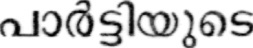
പാര്‍ട്ടിയുടെ
